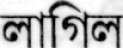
লাগিল
